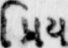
પ્રિય
